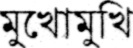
মুখোমুখি
